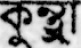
কুন্থ্রা
